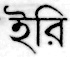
ইরি
